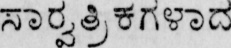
ಸಾರ್ವತ್ರಿಕಗಳಾದ
